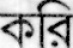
করি
